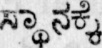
ಸ್ಥಾನಕ್ಕೆ
